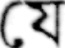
যে
